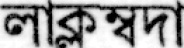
লাক্লম্বদা
